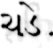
ચડે.
